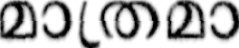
മാത്രമാ
